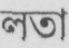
লতা
